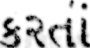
કરતાં
